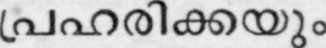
പ്രഹരിക്കുകയും
